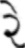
રે
